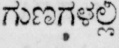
ಗುಣಗಳಲ್ಲಿ
